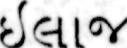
ઈલાજ
